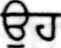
ਉਹ
